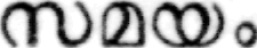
സമയം
